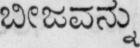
ಬೀಜವನ್ನು
